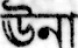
ঊনা
